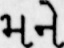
મને
